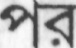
পর
